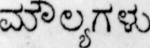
ಮೌಲ್ಯಗಳು
